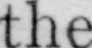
the
